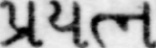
પ્રયત્ન
